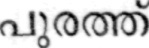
പുരത്ത്
